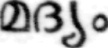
മദ്യം
